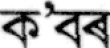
ক'বৰ
